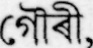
গৌৰী,
